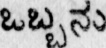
ಒಬ್ಬನು
